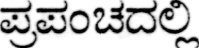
ಪ್ರಪಂಚದಲ್ಲಿ
